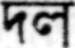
দল
